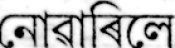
নোৱাৰিলে
